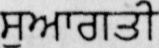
ਸੁਆਗਤੀ
